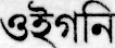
ওইগনি
